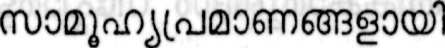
സാമൂഹ്യപ്രമാണങ്ങളായി
